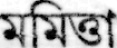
মমিত্তা
